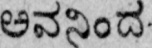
ಅವನಿಂದ
